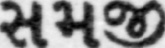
સમજી
